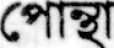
পোন্থা
